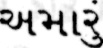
અમારું
